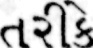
તરીકે
